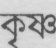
কৃষ্ণ
